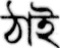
ঠাই
